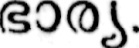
ഭാര്യ.
